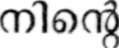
നിന്റെ
